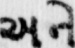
અને
